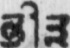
ਭੀੜ
